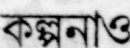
কল্পনাও
